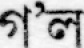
গ'ল
